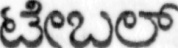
ಟೇಬಲ್
